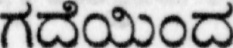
ಗದೆಯಿಂದ
